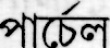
পাৰ্চেল
